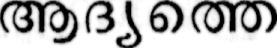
ആദ്യത്തെ
